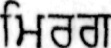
ਮਿਰਗ
